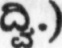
ದ್ವಿ)
